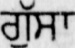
ਗੁੱਸਾ
